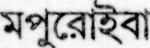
মপুরোইবা
